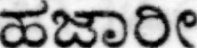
ಹಜಾರೀ
